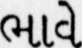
ભાવે
